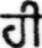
ਹੀ
